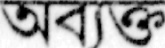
অব্যক্ত
